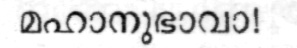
മഹാനുഭാവാ!
